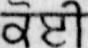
ਕੋਈ
